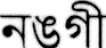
নঙগী
